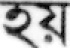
হয়
